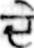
ਦੇ
